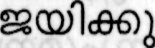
ജയിക്കു
